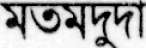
মতমদুদা
